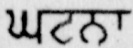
ਘਟਨਾ
